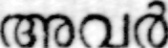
അവര്‍
